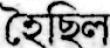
হৈছিল
